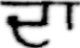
ਦਾ
